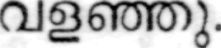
വളഞ്ഞു.
